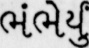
ભંભેર્યું
